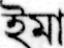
ইমা
